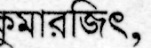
কুমারজিৎ,
